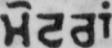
ਮੋਟਰਾਂ
